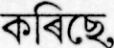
কৰিছে,
